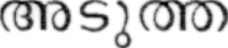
അടുത്ത
